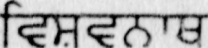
ਵਿਸ਼ਵਨਾਥ
